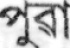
পুৱা
